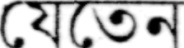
যেতেন
